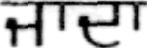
ਜਾਂਦਾ
